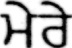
ਮੇਰੇ
